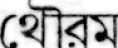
থৌরম
